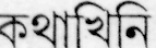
কথাখিনি
